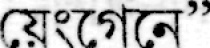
য়েংগেনে”
